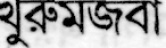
খুরুমজবা
